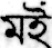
মই
